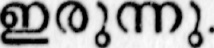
ഇരുന്നു.
